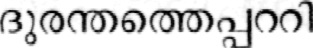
ദുരന്തത്തെപ്പററി
